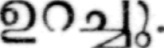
ഉറച്ചു.
